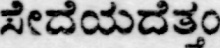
ಸೇದೆಯದೆತ್ತಂ
